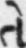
તે
